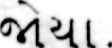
જોયા.
